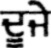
ਦੂਜੇ
